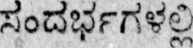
ಸಂದರ್ಭಗಳಲ್ಲಿ
